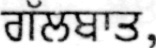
ਗੱਲਬਾਤ,
